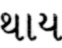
થાય
